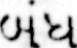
બંધ
